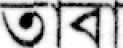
তাবা
